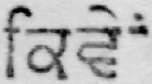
ਕਿਵੇਂ
